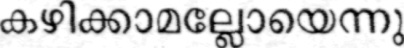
കഴിക്കാമല്ലോയെന്നു
